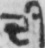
ਦੀ
